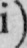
i)
